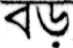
বড়
